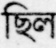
ছিল
